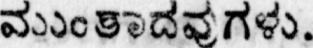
ಮುಂತಾದವುಗಳು.
